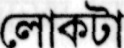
লোকটা
